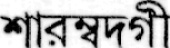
শারম্বদগী
